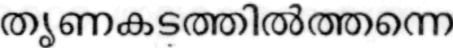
തൃണകടത്തില്‍ത്തന്നെ
